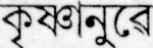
কৃষ্ণানুৱে
